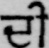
ਦੀ
